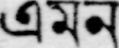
এমন
